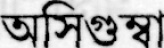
অসিগুম্বা
